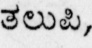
ತಲುಪಿ,
